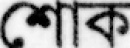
শোক
